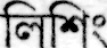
লিশিং
